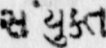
સંયુક્ત
